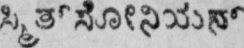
ಸ್ಮಿತ್‌ಸೋನಿಯನ್
